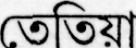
তেতিয়া
